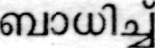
ബാധിച്ച്
